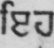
ਇਹ
